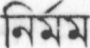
নির্মম
